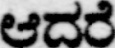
ಆದರೆ
